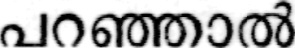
പറഞ്ഞാല്‍
